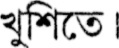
খুশিতে।
